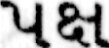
પક્ષ
